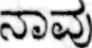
ನಾವು
